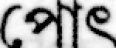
পোৎ
